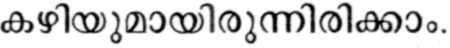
കഴിയുമായിരുന്നിരിക്കാം.
